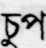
চুপ
